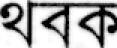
থবক
